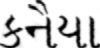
કનૈયા
